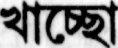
খাচ্ছো
